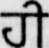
ਹੀ
